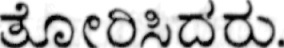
ತೋರಿಸಿದರು.
